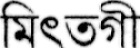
মিৎতগী
